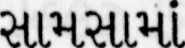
સામસામાં
